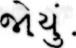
જોયું.
